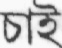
চাই
